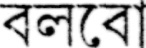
বলবো
